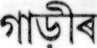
গাড়ীৰ
